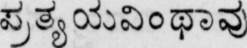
ಪ್ರತ್ಯಯವಿಂಥಾವು
